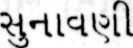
સુનાવણી
